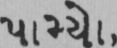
પામ્યો.
